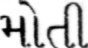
મોતી
